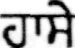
ਹਾਸੇ
